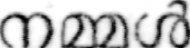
നമ്മള്‍
